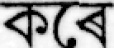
কৰে
